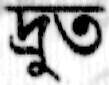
দ্রুত
